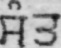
ਸੰਤ
